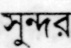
সুন্দর
